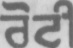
ਰੋਟੀ
